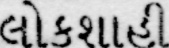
લોકશાહી
